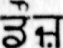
ਡੌਜ਼
